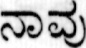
ನಾವು
